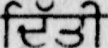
ਦਿੱਤੀ
